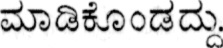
ಮಾಡಿಕೊಂಡದ್ದು.
